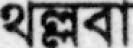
থল্লবা
